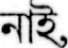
নাই,
